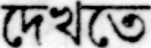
দেখতে
